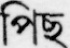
পিছ
